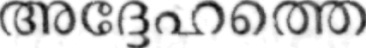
അദ്ദേഹത്തെ
